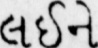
લઈને
